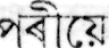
পৰীয়ে
